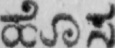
ಹೊಸ
